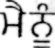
ਮੈਨੂੰ
